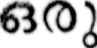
ഒരു
